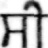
ਸੀ
